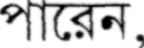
পারেন,
